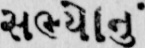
સભ્યોનું
